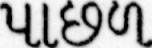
પાછળ
